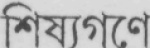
শিষ্যগণে
